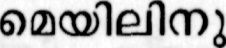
മെയിലിനു
